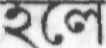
হলে
